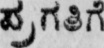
ಪ್ರಗತಿಗೆ
